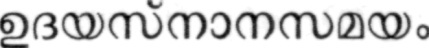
ഉദയസ്നാനസമയം
